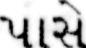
પાસે
